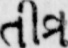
તીવ્ર
